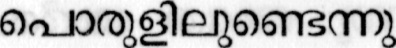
പൊരുളിലുണ്ടെന്നു
